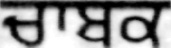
ਚਾਬਕ
